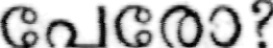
പേരോ?
